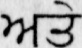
ਅਤੇ
